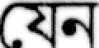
যেন
